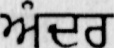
ਅੰਦਰ
